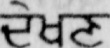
ਦੇਖਣ
